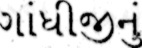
ગાંધીજીનું
